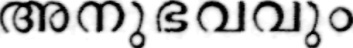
അനുഭവവും
